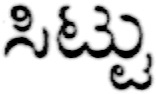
ಸಿಟ್ಟು
